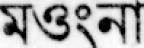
মওংনা
